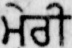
ਮੇਰੀ
